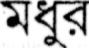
মধুর
